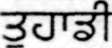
ਤੁਹਾਡੀ
